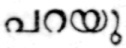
പറയു
